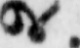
જ.
